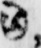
છે,
